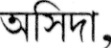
অসিদা,
